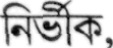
নিৰ্ভীক,
